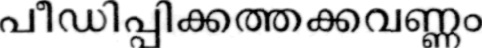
പീഡിപ്പിക്കത്തക്കവണ്ണം
